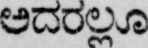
ಅದರಲ್ಲೂ
